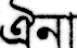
ঐনা
